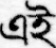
এই
